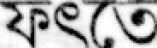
ফৎতে
